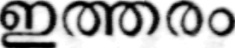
ഇത്തരം
